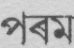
পৰম
